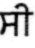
ਸੀ
